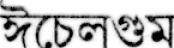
ঈচেলগুম
